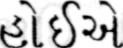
હોઈએ
